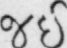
જઇ
